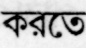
করতে
